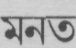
মনত
